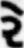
રે
